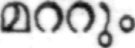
മററും
